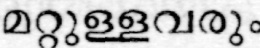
മറ്റുള്ളവരും
